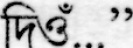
দিওঁ..."
